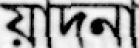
য়াদনা
